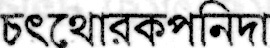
চৎথোরকপনিদা
